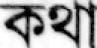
কথা
